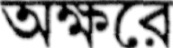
অক্ষরে
